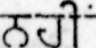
ਨਹੀਂ
